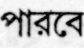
পারবে
